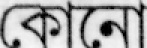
কোনো
